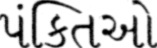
પંક્તિઓ
